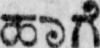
ಹಾಗೆ
